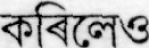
কৰিলেও
